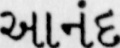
આનંદ
